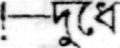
!—দুধে
